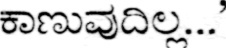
ಕಾಣುವುದಿಲ್ಲ..."
